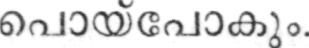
പൊയ്പോകും.
